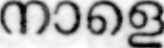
നാളെ
